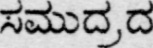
ಸಮುದ್ರದ
